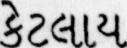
કેટલાય
